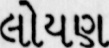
લોયણ
